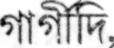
গার্গীদি,
